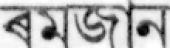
ৰমজান
